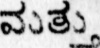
ಮತ್ತು
